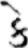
કે
